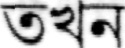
তখন
